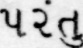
પરંતુ
